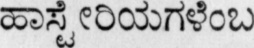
ಹಾಸ್ಟೇರಿಯಗಳೆಂಬ
